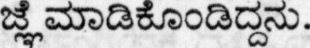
ಜ್ಞೆಮಾಡಿಕೊಂಡಿದ್ದನು.
